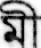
মী
